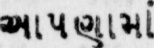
આપણામાં
